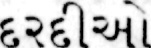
દરદીઓ
